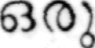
ഒരു
